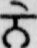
ਨੇ
